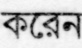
করেন
